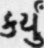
કર્યું
